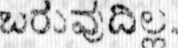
ಬರುವುದಿಲ್ಲ.
